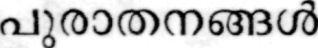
പുരാതനങ്ങള്‍
